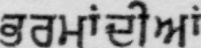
ਭਰਮਾਂਦੀਆਂ
